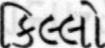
કિલ્લો
